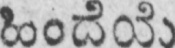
ಹಿಂದೆಯೆ
